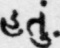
હતું.
